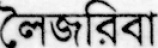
লৈজরিবা
